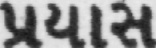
પ્રયાસ
